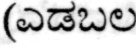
(ಎಡಬಲ
